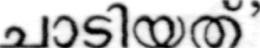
ചാടിയത്’
